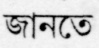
জানতে
